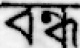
বন্ধ
